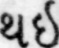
થઈ
